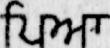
ਪਿਆ
